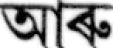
আৰু
